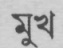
মুখ
